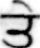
ਤੇ
